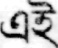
এই
